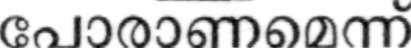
പോരാണമെന്ന്
